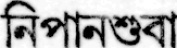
নিপানশুবা
